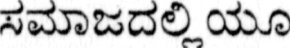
ಸಮಾಜದಲ್ಲಿಯೂ
